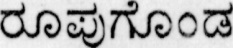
ರೂಪುಗೊಂಡ
